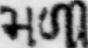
મળી
